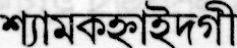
শ্যামকহ্ণাইদগী
